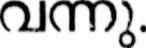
വന്നു.
